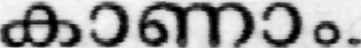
കാണാം.
